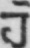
ਹੋ
